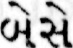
બેસે
